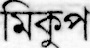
মিকুপ
